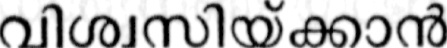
വിശ്വസിയ്ക്കാന്‍
